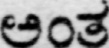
ಅಂತ
